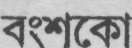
বংশকো
